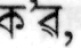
ক'ৱ,
